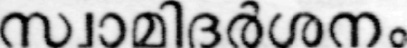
സ്വാമിദര്‍ശനം
